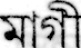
মাগী
